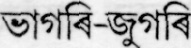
ভাগৰি-জুগৰি
